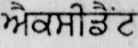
ਐਕਸੀਡੈਂਟ
